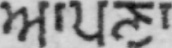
ਆਪਣਾ
